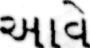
આવે
